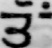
ਤੋਂ
